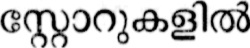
സ്റ്റോറുകളില്‍
